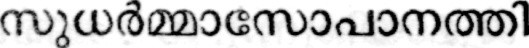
സുധര്‍മ്മാസോപാനത്തി
